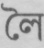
লৈ
